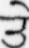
ਤੇ
